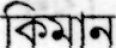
কিমান
